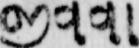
જીવવા
